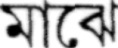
মাঝে
